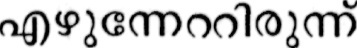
എഴുന്നേററിരുന്ന്
